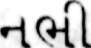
નભી
